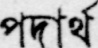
পদার্থ
